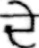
ਦੇ
